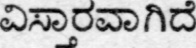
ವಿಸ್ತಾರವಾಗಿದೆ
